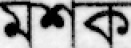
মশক
